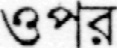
ওপর
